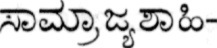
ಸಾಮ್ರಾಜ್ಯಶಾಹಿ-
